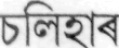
চলিহাৰ
